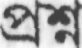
প্রশ্ন
